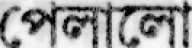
পেলালো
